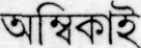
অম্বিকাই
